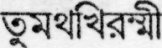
তুমথখিরম্মী
